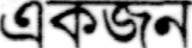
একজন
